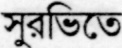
সুরভিতে
